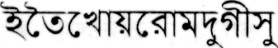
ইতৈখোয়রোমদুগীসু
